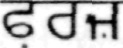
ਫ਼ਰਜ਼
